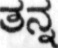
ತನ್ನ
